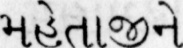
મહેતાજીને
